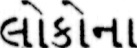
લોકોના
